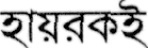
হায়রকই
